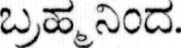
ಬ್ರಹ್ಮನಿಂದ.
